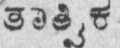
ತಾತ್ವಿಕ
